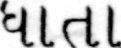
ધાતા
